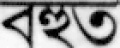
বহুত
